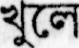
খুলে
